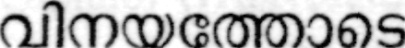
വിനയത്തോടെ
